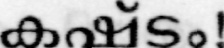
കഷ്ടം!
